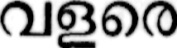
വളരെ
